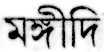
মঙ্গীদি
